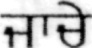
ਜਾਚੇ
